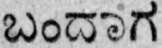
ಬಂದಾಗ
